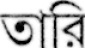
তারি
